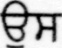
ਉਸ
